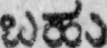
ಬಹು
